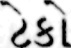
ટેકો
